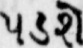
પડશે
